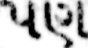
પણ
